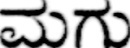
ಮಗು
